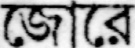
জোরে
